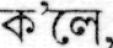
ক'লে,
